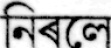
নিৰলে
